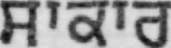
ਸਾਕਾਰ
